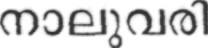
നാലുവരി
